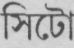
সিটো
